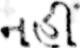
નહીં
